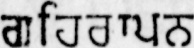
ਗਹਿਰਾਪਨ
